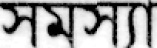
সমস্যা
